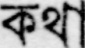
কথা
